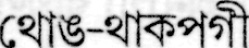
থোঙ-থাকপগী
